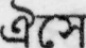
ঐসৈ
